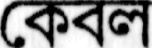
কেবল
